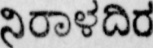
ನಿರಾಳದಿರ
